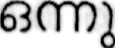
ഒന്നു
